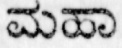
ಮಹಾ
